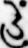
હેં
